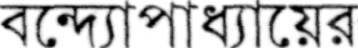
বন্দ্যোপাধ্যায়ের
